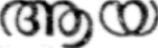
ആയ
